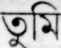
তুমি
